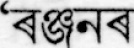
'ৰঞ্জনৰ
